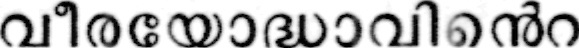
വീരയോദ്ധാവിന്റെ
